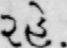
રહે.
